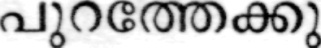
പുറത്തേക്കു
